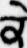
ਕੇ
